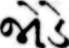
જોડે
